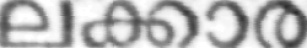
ലക്കാര
